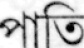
পাতি
